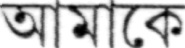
আমাকে
